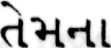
તેમના
